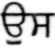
ਉਸ
